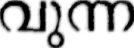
വുന്ന
